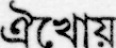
ঐখোয়
